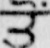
ਤੋਂ
